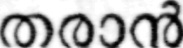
തരാന്‍
